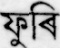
ফুৰি
